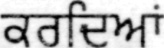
ਕਰਦਿਆਂ
